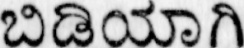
ಬಿಡಿಯಾಗಿ
